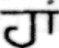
ਹਾਂ
